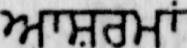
ਆਸ਼ਰਮਾਂ
